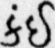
કંઈ
